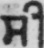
ਸੀ
